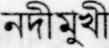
নদীমুখী
